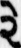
રે
